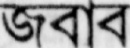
জবাব
